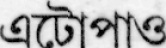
এটোপাও
